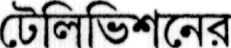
টেলিভিশনের
